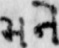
મને
